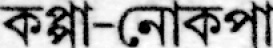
কপ্পা-নোকপা
